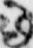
છે
